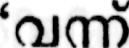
‘വന്ന്
